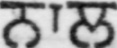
ਨਾਲ
